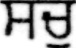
ਸਚੁ
